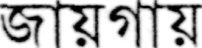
জায়গায়
